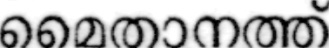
മൈതാനത്ത്
